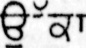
ਉੱਕਾ
